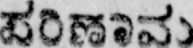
ಪರಿಣಾಮ
